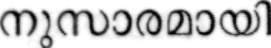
നുസാരമായി
